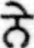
ਨੇ
